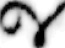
જ
